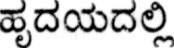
ಹೃದಯದಲ್ಲಿ
